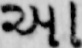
આ
